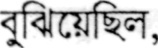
বুঝিয়েছিল,
